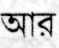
আর
